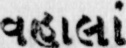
વહાલાં
